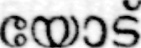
യോട്
